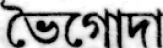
ভৈগোদা
